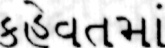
કહેવતમાં
